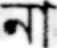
না
